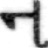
ન
